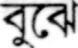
বুঝে
